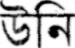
উনি
